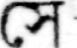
সে
